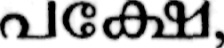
പക്ഷേ,
